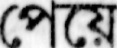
পেয়ে
